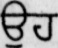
ਉਹ
